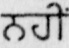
ਨਹੀਂ
